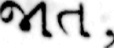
જાત,
